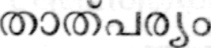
താത്പര്യം
